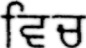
ਵਿਚ
